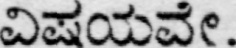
ವಿಷಯವೇ.
